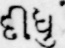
દીધું
